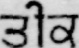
ਤੀਕ
